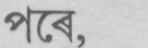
পৰে,
